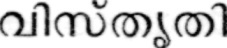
വിസ്ത്യതി
